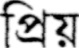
প্রিয়
